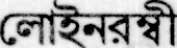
লোইনরম্বী
